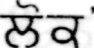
ਲੋਕ'
